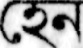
হেন
